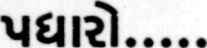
પધારો........
